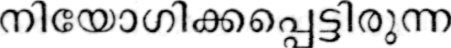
നിയോഗിക്കപ്പെട്ടിരുന്ന
